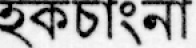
হকচাংনা
